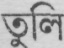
তুলি
